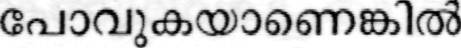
പോവുകയാണെങ്കില്‍
